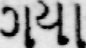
ગયા
